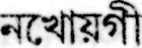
নখোয়গী
